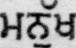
ਮਨੁੱਖ
